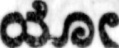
ಯೋ
